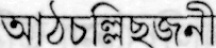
আঠচল্লিছজনী
